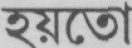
হয়তো
